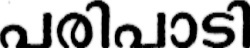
പരിപാടി
